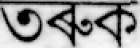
তৰুক
